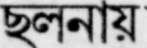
ছলনায়
